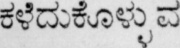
ಕಳೆದುಕೊಳ್ಳುವ
